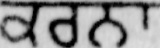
ਕਰਨਾ
